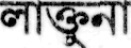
লাক্তুনা
